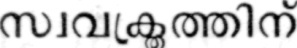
സ്വവക്ത്രത്തിന്
